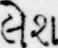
લેશ
